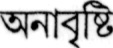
অনাবৃষ্টি
